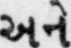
અને
